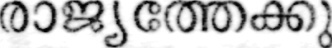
രാജ്യത്തേക്കു
